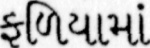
ફળિયામાં
